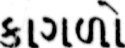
કાગળો
